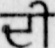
ਦੀ
